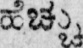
ಹೆಚ್ಚು
